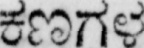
ಕಣಗಳ
